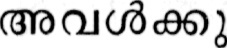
അവള്‍ക്കു
